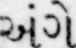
અંગે
